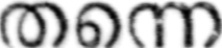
തന്നെ
